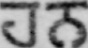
ਹਨ
